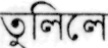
তুলিলে
